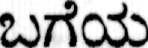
ಬಗೆಯ
